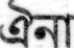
ঐনা
